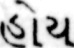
હોય
